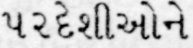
પરદેશીઓને
